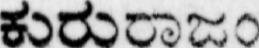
ಕುರುರಾಜಂ
